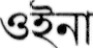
ওইনা
